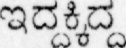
ಇದ್ದಕ್ಕಿದ್ದ
